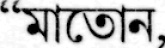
“মাতোন
